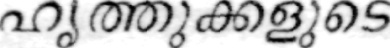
ഹൃത്തുക്കളുടെ
